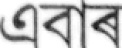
এবাৰ
